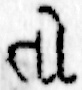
તો
